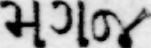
મગજ
